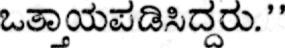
ಒತ್ತಾಯಪಡಿಸಿದ್ದರು."
